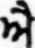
ਐ
